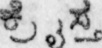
ಕ್ರೈಸ್ತ
